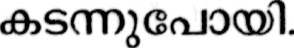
കടന്നുപോയി.
